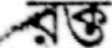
রক্ত
